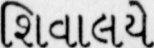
શિવાલયે
